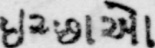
ઇચ્છાઓ
